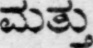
ಮತ್ತು
